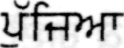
ਪੁੱਜਿਆ
